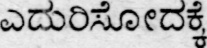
ಎದುರಿಸೋದಕ್ಕೆ
